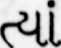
ત્યાં
